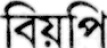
বিয়পি
